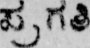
ಪ್ರಗತಿ
